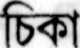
চিকা
